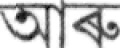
আৰু
